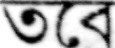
তবে
